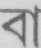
বা
